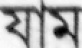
যাম
